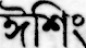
ঈশিং
